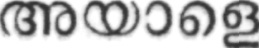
അയാളെ
